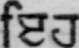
ਇਹ
